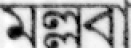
মল্লবা
